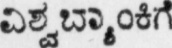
ವಿಶ್ವಬ್ಯಾಂಕಿಗೆ
